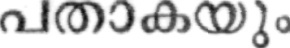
പതാകയും
